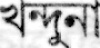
খন্দুনা
